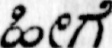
ಹೀಗೆ
